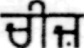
ਚੀਜ਼
